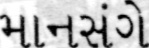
માનસંગે
